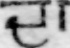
ਦਾ
